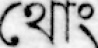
থোং
